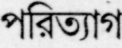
পরিত্যাগ
